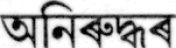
অনিৰুদ্ধৰ
